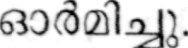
ഓര്‍മിച്ചു.
